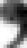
পল্লকই
